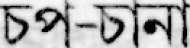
চপ-চানা
